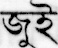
জুই
